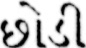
છોડી
